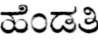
ಹೆಂಡತಿ
